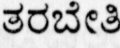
ತರಬೇತಿ
